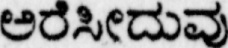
ಅರೆಸೀದುವು
